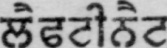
ਲੈਫਟੀਨੈਟ
